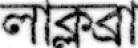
লাক্লব্রা
